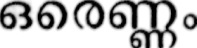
ഒരെണ്ണം
